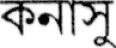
কনাসু
